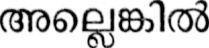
അല്ലെങ്കില്‍
